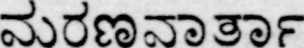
ಮರಣವಾರ್ತಾ
